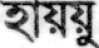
হায়য়ু
